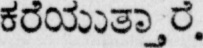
ಕರೆಯುತ್ತಾರೆ.
